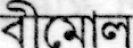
বীমোল
